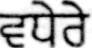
ਵਧੇਰੇ
